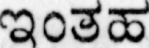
ಇಂತಹ
